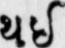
થઈ
